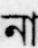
না
